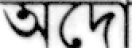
অদো
